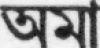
অমা
